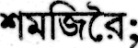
শমজিরৈ;
